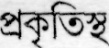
প্রকৃতিস্থ
